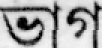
ভাগ
